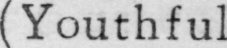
(Youthful
